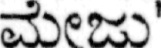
ಮೇಜು’
